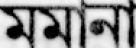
মমানা
